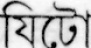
যিটো
